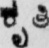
ಕೃತಿ
